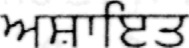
ਅਸ਼ਾਇਤ
